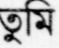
তুমি
